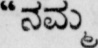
“ನಮ್ಮ
